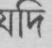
যদি
